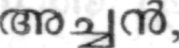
അച്ചന്‍,
